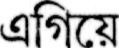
এগিয়ে
